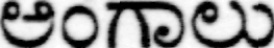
ಅಂಗಾಲು
